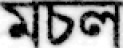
মচল
